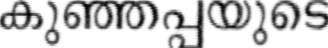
കുഞ്ഞപ്പയുടെ
